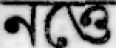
নত্তে
